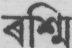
ৰশ্মি
